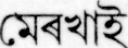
মেৰখাই
